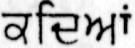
ਕਦਿਆਂ
